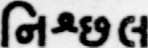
નિશ્ર્છલ
